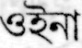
ওইনা
